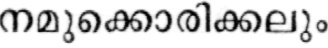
നമുക്കൊരിക്കലും
